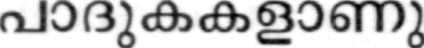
പാദുകകളാണു
